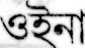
ওইনা
